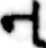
ન
